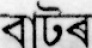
বাটৰ
